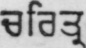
ਚਰਿਤ੍ਰ
